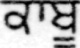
ਕਾਬੂ
